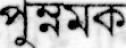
পুম্নমক
